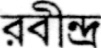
রবীন্দ্র
